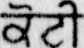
ਕੋਟੀ
